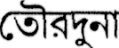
তৌরদুনা
